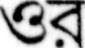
ওর
